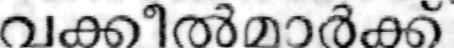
വക്കീല്‍മാര്‍ക്ക്
